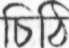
চিঠি
